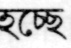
হচ্ছে
